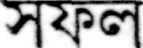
সফল
